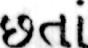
છતાં
